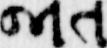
જાત
